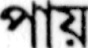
পায়
